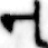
ન
